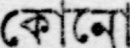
কোনো
